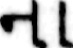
ના
